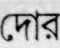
দোর
